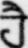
ਹੈ
